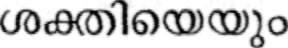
ശക്തിയെയും
